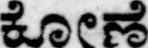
ಕೋಣೆ
